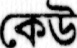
কেউ
